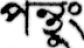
পন্থং
